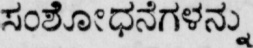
ಸಂಶೋಧನೆಗಳನ್ನು
